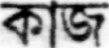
কাজ
